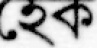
হেক
